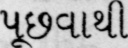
પૂછવાથી
